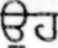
ਉਹ
